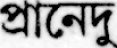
প্রানেদু
